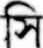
সি
